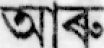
আৰু
